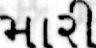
મારી
